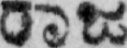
ರಾಜ
